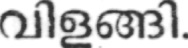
വിളങ്ങി.
